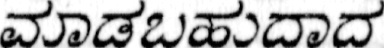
ಮಾಡಬಹುದಾದ
